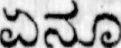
ಏನೂ
